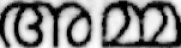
അമ്മ
